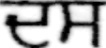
ਦਸ
